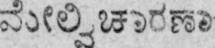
ಮೇಲ್ವಿಚಾರಣಾ
